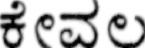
ಕೇವಲ
